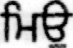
ਮਿਊ
